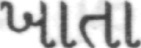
ખાતા
